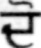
ਦੋ
